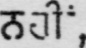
ਨਹੀਂ,
